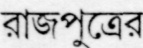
রাজপুত্রের
